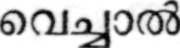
വെച്ചാല്‍
